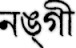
নঙগী
